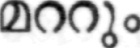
മററും
